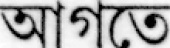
আগতে
